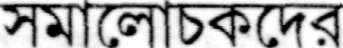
সমালোচকদের
